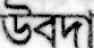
উবদা
